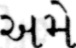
અમે
